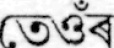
তেওঁৰ
